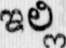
ಇಲ್ಲಿ
